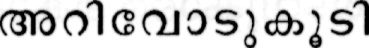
അറിവോടുകൂടി
